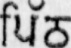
ਪਿੱਠ
